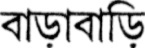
বাড়াবাড়ি
